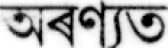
অৰণ্যত
